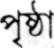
পৃষ্ঠা
